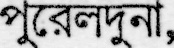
পুরেলদুনা,
